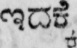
ಇದಕ್ಕೆ
